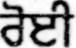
ਰੋਈ
